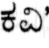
ಕವಿ'
